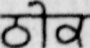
ਠੀਕ
